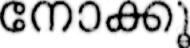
നോക്കൂ
